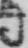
ਹੈ
